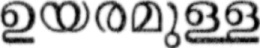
ഉയരമുള്ള
